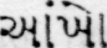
આંખો
